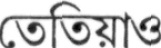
তেতিয়াও
